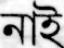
নাই
